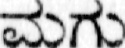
ಮಗು
